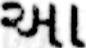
આ
